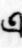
এ
